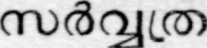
സര്‍വ്വത്ര
